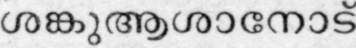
ശങ്കുആശാനോട്
